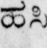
ಹಸಿ
